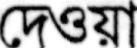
দেওয়া
